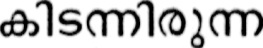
കിടന്നിരുന്ന
